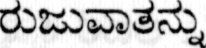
ರುಜುವಾತನ್ನು
